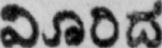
ಮೀರಿದ
